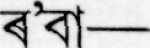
ৰ'বা-
